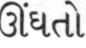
ઊંઘતો
